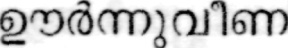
ഊര്‍ന്നുവീണ
